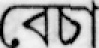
বেচা
